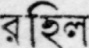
রহিল
